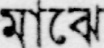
মাঝে
